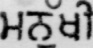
ਮਨੁੱਖੀ
